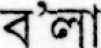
ব'লা
